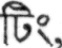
টিং,
